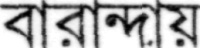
বারান্দায়
